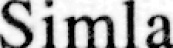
Simla
